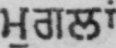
ਮੁਗਲਾਂ
